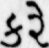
કરે
